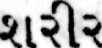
શરીર
